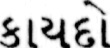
કાયદો
